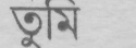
তুমি
